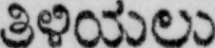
ತಿಳಿಯಲು
